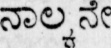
ನಾಲ್ಕನೇ
